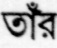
তাঁর
